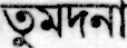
তুমদনা
